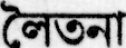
লৈতনা
